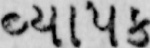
વ્યાપક
